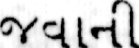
જવાની
